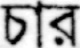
চার
